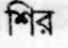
শির
